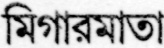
মিগারমাতা
